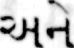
અને
